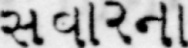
સવારના
